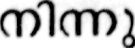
നിന്നു
